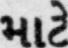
માટે
